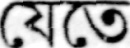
যেতে
